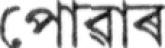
পোৱাৰ
